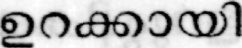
ഉറക്കായി
